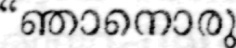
“ഞാനൊരു
